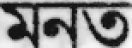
মনত
